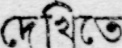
দেখিতে
